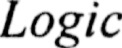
Logic
